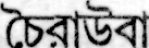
চৈরাউবা
